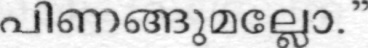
പിണങ്ങുമല്ലോ."
